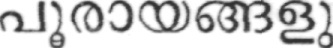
പൂരായങ്ങളു
